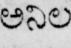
ಅನಿಲ
